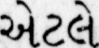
એટલે
